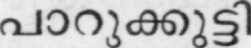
പാറുക്കുട്ടി
